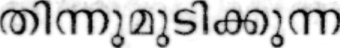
തിന്നുമുടിക്കുന്ന
